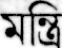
মন্ত্রি
